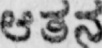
ಆತನ
